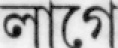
লাগে
